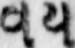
વય
